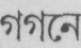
গগনে
